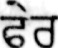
ਫੇਰ
